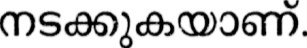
നടക്കുകയാണ്.
